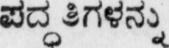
ಪದ್ಧತಿಗಳನ್ನು
